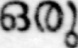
ഒരു
